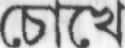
চোখে
